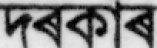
দৰকাৰ
